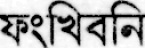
ফংখিবনি
